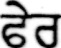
ਫੇਰ
